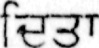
ਦਿਤਾ
